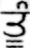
ਤੂੰ
